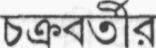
চক্রবর্তীর
